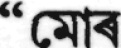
"মোৰ
